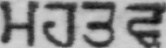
ਮਹਤਵ
